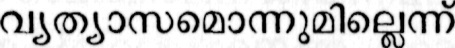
വ്യത്യാസമൊന്നുമില്ലെന്ന്
